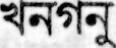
খনগনু
